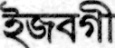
ইজবগী
